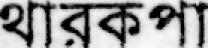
থারকপা
